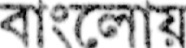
বাংলোয়
